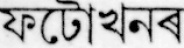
ফটোখনৰ
